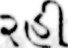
રહી
